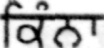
ਕਿੰਨਾ
